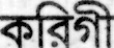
করিগী
